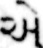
એ
